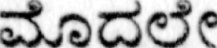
ಮೊದಲೇ
